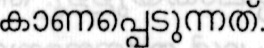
കാണപ്പെടുന്നത്.
